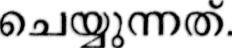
ചെയ്യുന്നത്.
